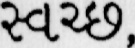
સ્વચ્છ,
